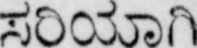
ಸರಿಯಾಗಿ
